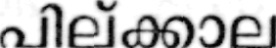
പില്ക്കാല
